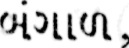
બંગાળ,
